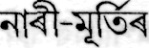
নাৰী-মূর্তিৰ
